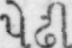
પેઢી
